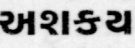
અશક્ય
